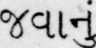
જવાનું
